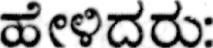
ಹೇಳಿದರು:
